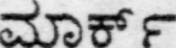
ಮಾರ್ಕ್
